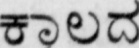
ಕಾಲದ
